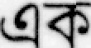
এক
